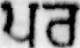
ਪਰ
